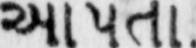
આપતા.
